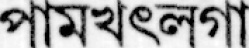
পামখৎলগা
